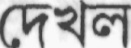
দেখল
